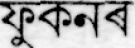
ফুকনৰ
